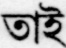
তাই
